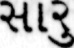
સારુ
